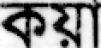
কয়া
